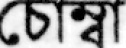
চোম্বা
